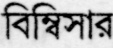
বিম্বিসার
